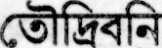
তৌদ্রিবনি
